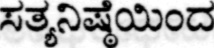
ಸತ್ಯನಿಷ್ಠೆಯಿಂದ
